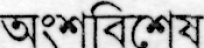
অংশবিশেষ
